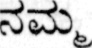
ನಮ್ಮ
